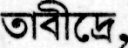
তাবীদ্রে,
